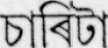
চাৰিটা
